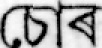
চোৰ
